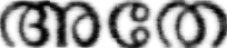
അതേ
